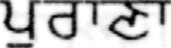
ਪੁਰਾਣਾ
